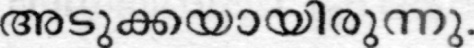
അടുക്കയായിരുന്നു.
